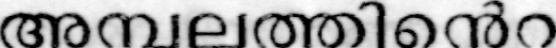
അമ്പലത്തിന്റെ
